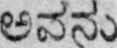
ಅವನು
